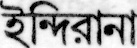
ইন্দিরানা
